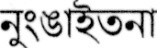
নুংঙাইতনা
